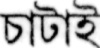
চাটাই
